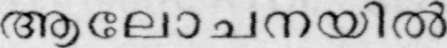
ആലോചനയില്‍
